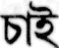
চাই
